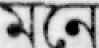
মনে
